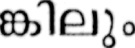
ങ്കിലും
